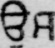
ਉਸ
